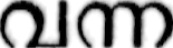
വന്ന
